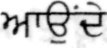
ਆਉਂਦੇ
